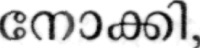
നോക്കി,
